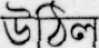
উঠিল
